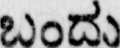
ಬಂದು
